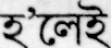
হ'লেই
